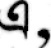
এ,
